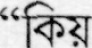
"কিয়
